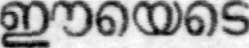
ഈയെടെ
